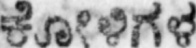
ಕೋಳಿಗಳ
